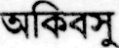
অকিবসু
